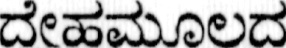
ದೇಹಮೂಲದ
